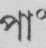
পা
